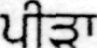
ਪੀੜਾ
